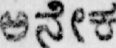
ಅನೇಕ
